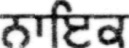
ਨਾਇਕ
